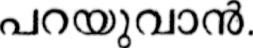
പറയുവാന്‍.
